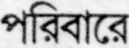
পরিবারে
